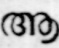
ആ
